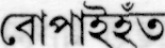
বোপাইহঁত
